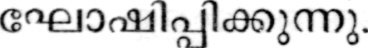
ഘോഷിപ്പിക്കുന്നു.
